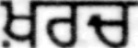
ਖ਼ਰਚ
